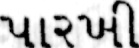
પારખી
